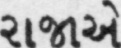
રાજાએ
